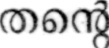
തന്റെ
